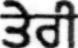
ਤੇਰੀ
